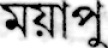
ময়াপু
